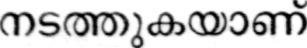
നടത്തുകയാണ്
